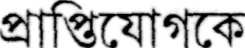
প্রাপ্তিযোগকে
